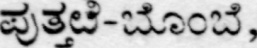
ಪುತ್ತೞೆ-ಬೊಂಬೆ,
